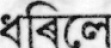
ধৰিলে
